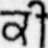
ਕੀ
